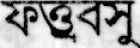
ফত্ত্রবসু
